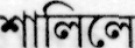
শালিলে
